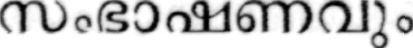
സംഭാഷണവും
